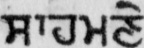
ਸਾਹਮਣੇ
